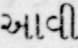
આવી
